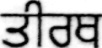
ਤੀਰਥ
